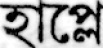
হাপ্লে
